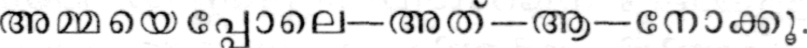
അമ്മയെപ്പോലെ-അത്-ആ-നോക്കൂ.
